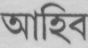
আহিব
